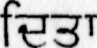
ਦਿਤਾ
